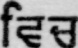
ਵਿਚ
